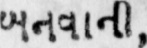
બનવાની,
